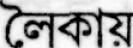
লৈকায়
